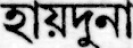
হায়দুনা
